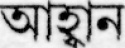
আহ্বান
